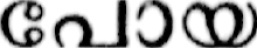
പോയ
